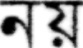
নয়
